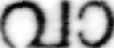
വാ
